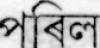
পৰিল
